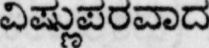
ವಿಷ್ಣುಪರವಾದ
